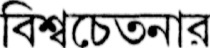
বিশ্বচেতনার
